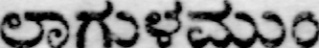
ಲಾಗುಳಮುಂ
